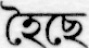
হৈছে
